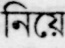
নিয়ে
